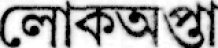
লোকঅপ্তা
